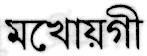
মখোয়গী
